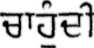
ਚਾਹੁੰਦੀ
